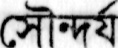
সৌন্দর্য
